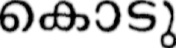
കൊടു
